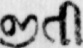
જીતી
